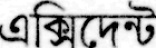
এক্সিদেন্ট
